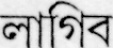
লাগিব
